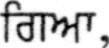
ਗਿਆ,
